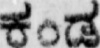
ಕಂಡ
